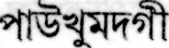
পাউখুমদগী
